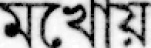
মখোয়
